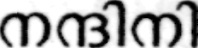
നന്ദിനി
